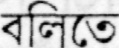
বলিতে
